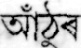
আঁঠুৰ
